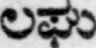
ಲಘು
